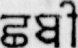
ਛਬੀ
